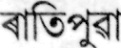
ৰাতিপুৱা
